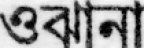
ওঝানা
